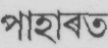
পাহাৰত
